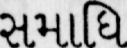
સમાધિ
